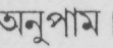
অনুপাম
